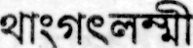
থাংগৎলম্মী
